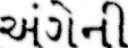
અંગેની
